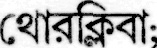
থোরক্লিবা;
